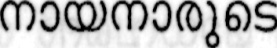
നായനാരുടെ
